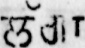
ਲੱਗਾ
